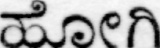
ಹೋಗಿ
